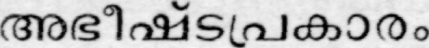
അഭീഷ്ടപ്രകാരം
